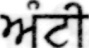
ਅੰਟੀ
